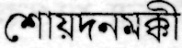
শোয়দনমক্কী
